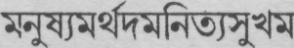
মনুষ্যমৰ্থদমনিত্যসুখম
